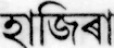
হাজিৰা
